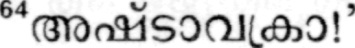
64അഷ്ടാവക്രാ!'
